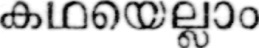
കഥയെല്ലാം
